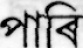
পাৰি
